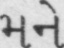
મને
